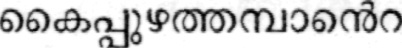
കൈപ്പുഴത്തമ്പാന്റെ
